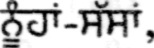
ਨੂੰਹਾਂ-ਸੱਸਾਂ,
